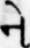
ને
